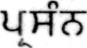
ਪ੍ਰਸੰਨ
